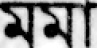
মমা
